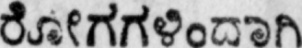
ರೋಗಗಳಿಂದಾಗಿ
